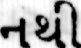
નથી
